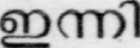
ഇന്നി
